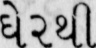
ઘેરથી
